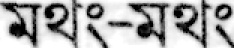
মথং-মথং
